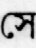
সে
